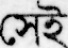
সেই
